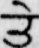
ਤੇ
